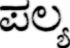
ಪಲ್ಯ
